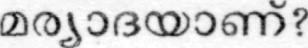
മര്യാദയാണ്?
